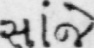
સાંજે
